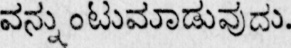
ವನ್ನುಂಟುಮಾಡುವುದು.
